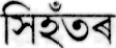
সিহঁতৰ
